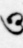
ও
